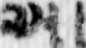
આ
